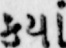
ક્યાં
